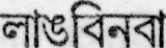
লাঙবিনবা
